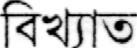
বিখ্যাত
